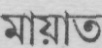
মায়াত
